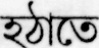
হঠাতে
